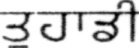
ਤੁਹਾਡੀ
